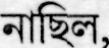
নাছিল,
